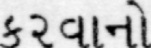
કરવાનો
